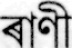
ৰাণী
